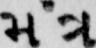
મંત્ર
